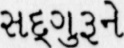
સદગુરૂને
